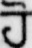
ਹੋ
